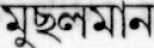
মুছলমান
